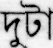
দুটা
